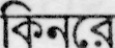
কিনরে
